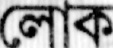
লোক
